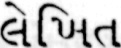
લેખિત
